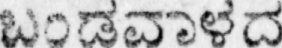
ಬಂಡವಾಳದ
